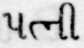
પત્ની
